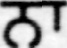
ਨਾ
